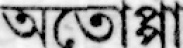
অতোপ্পা
